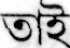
তাই
